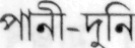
পানী-দুনি
